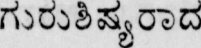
ಗುರುಶಿಷ್ಯರಾದ
